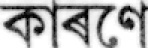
কাৰণে
